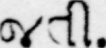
જતી.
